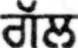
ਗੱਲ
